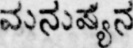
ಮನುಷ್ಯನ
